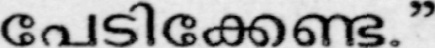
പേടിക്കേണ്ട.”
